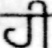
ਹੀ
